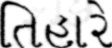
તિહારે
